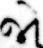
જો
